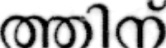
ത്തിന്
